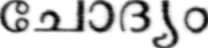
ചോദ്യം
